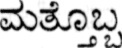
ಮತ್ತೊಬ್ಬ
